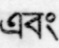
এবং
